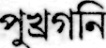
পুখ্রগনি
